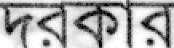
দরকার
